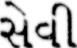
સેવી
